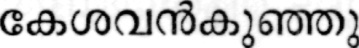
കേശവന്‍കുഞ്ഞു
